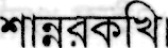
শান্নরকখি।
